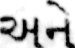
અને
